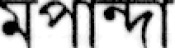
মপান্দা
